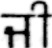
ਜੀ
